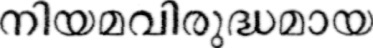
നിയമവിരുദ്ധമായ
